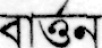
বার্ত্তন
